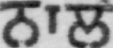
ਨਾਲ
